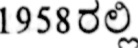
1958ರಲ್ಲಿ
